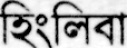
হিংলিবা
